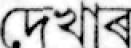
দেখাৰ
